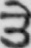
ਤੇ
